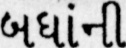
બધાંની
